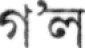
গ'ল
